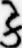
કે
